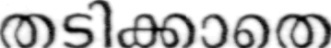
തടിക്കാതെ
